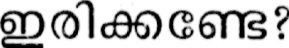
ഇരിക്കണ്ടേ?
